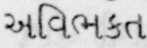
અવિભક્ત
